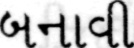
બનાવી
